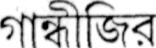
গান্ধীজির
